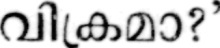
വിക്രമാ?’
